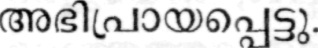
അഭിപ്രായപ്പെട്ടു.
